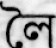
লৈ
